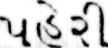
પહેરી
